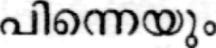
പിന്നെയും
